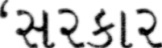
'સરકાર
